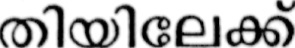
തിയിലേക്ക്
